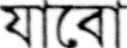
যাবো
